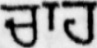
ਚਾਹ
